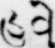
હવે
